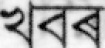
খবৰ
